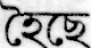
হৈছে
